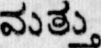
ಮತ್ತು
